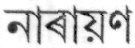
নাৰায়ণ
